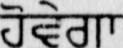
ਹੋਵੇਗਾ
